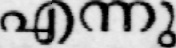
എന്നു
